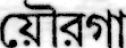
য়ৌরগা
